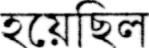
হয়েছিল
